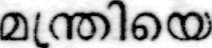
മന്ത്രിയെ
